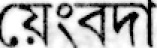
য়েংবদা
